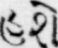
હશે
